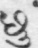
છું
